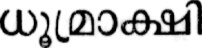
ധൂമ്രാക്ഷി
